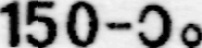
150-ാം
